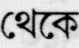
থেকে
